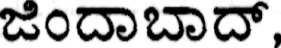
ಜಿಂದಾಬಾದ್,
